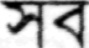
সব
